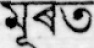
মূৰত
